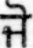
ਜੋ
